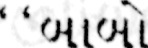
"બાબો
